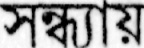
সন্ধ্যায়
